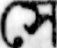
সে
